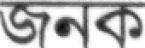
জনক
